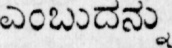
ಎಂಬುದನ್ನು
